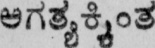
ಅಗತ್ಯಕ್ಕಿಂತ
